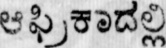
ಆಫ್ರಿಕಾದಲ್ಲಿ
